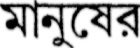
মানুষের
